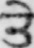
ਤੇ
